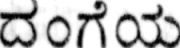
ದಂಗೆಯ
